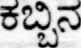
ಕಬ್ಬಿನ
